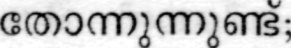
തോന്നുന്നുണ്ട്;
